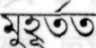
মুহূৰ্তত
